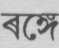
ৰঙ্গে
